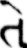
તે
